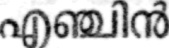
എഞ്ചിന്‍
